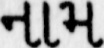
નામ
